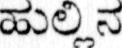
ಹುಲ್ಲಿನ
